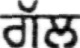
ਗੱਲ
